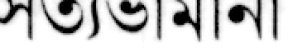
সত্যভামানা
